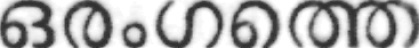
ഒരംഗത്തെ
